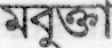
মবুক্তা
